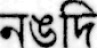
নঙদি
